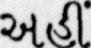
અહીં
